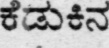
ಕೆಡುಕಿನ
